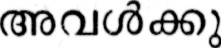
അവള്‍ക്കു
